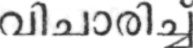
വിചാരിച്ച്
